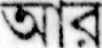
আর
